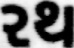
રથ
